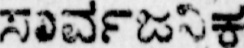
ಸಾರ್ವಜನಿಕ
